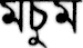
মচুম
